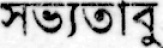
সভ্যতাবু
